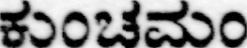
ಕುಂಚಮಂ
